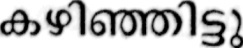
കഴിഞ്ഞിട്ടു
